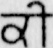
ਕੀ
